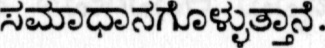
ಸಮಾಧಾನಗೊಳ್ಳುತ್ತಾನೆ.
